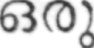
ഒരു
